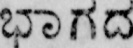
ಭಾಗದ
